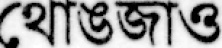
থোঙজাও
